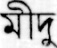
মীদু
